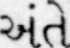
અંતે
